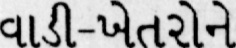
વાડી-ખેતરોને
